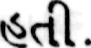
હતી.
